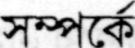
সম্পর্কে
